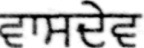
ਵਾਸਦੇਵ
